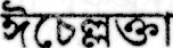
ঈচেল্লক্তা
